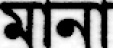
মানা
